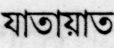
যাতায়াত
